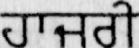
ਹਾਜਰੀ
